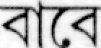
বাবে
